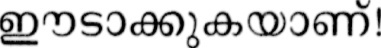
ഈടാക്കുകയാണ്!
